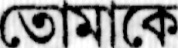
তোমাকে
